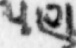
પણ
